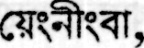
য়েংনীংবা,
